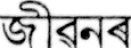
জীৱনৰ
